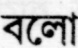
বলো
